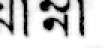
য়াম্না
